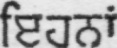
ਇਹਨਾਂ
